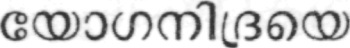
യോഗനിദ്രയെ
